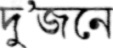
দু’জনে
